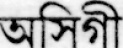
অসিগী
